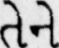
તેને
